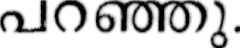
പറഞ്ഞു.
